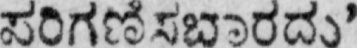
ಪರಿಗಣಿಸಬಾರದು’
